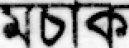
মচাক
